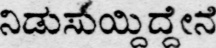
ನಿಡುಸುಯ್ದಿದ್ದೇನೆ
